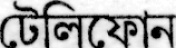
টেলিফোন
